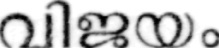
വിജയം
